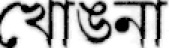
খোঙনা
